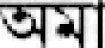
অমা
